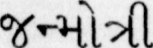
જન્મોત્રી
